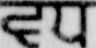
ਵਧ
